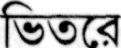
ভিতরে
